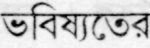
ভবিষ্যতের
